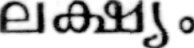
ലക്ഷ്യം
